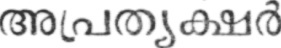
അപ്രത്യക്ഷര്‍
